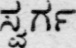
ಸ್ವರ್ಗ
